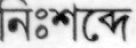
নিঃশব্দে
